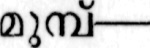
മുമ്പ്-
